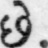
છે.
